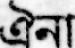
ঐনা
